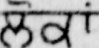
ਲੋਕਾਂ
